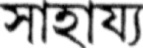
সাহায্য
